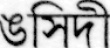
ঙসিদী
